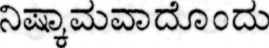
ನಿಷ್ಕಾಮವಾದೊಂದು
